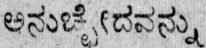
ಅನುಚ್ಛೇದವನ್ನು
